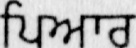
ਪਿਆਰ
